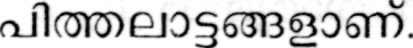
പിത്തലാട്ടങ്ങളാണ്.
